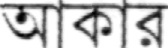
আকার
